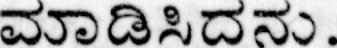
ಮಾಡಿಸಿದನು.
